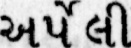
અર્પેલી
